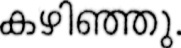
കഴിഞ്ഞു.
